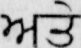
ਅਤੇ
